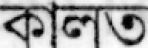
কালত
